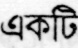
একটি
